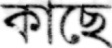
কাছে
